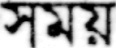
সময়
